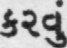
કરવું
